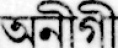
অনীগী
